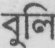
বুলি
